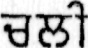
ਚਲੀ
